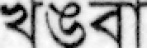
খঙবা
